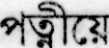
পত্নীয়ে
